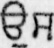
ਉਸ
